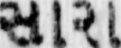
સારા
